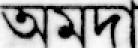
অমদা
